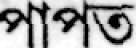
পাপত
